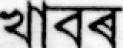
খাবৰ
